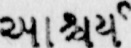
આશ્ચર્ય
